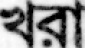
খরা
